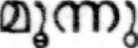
മൂന്നു
